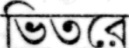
ভিতরে
